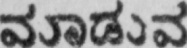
ಮಾಡುವ
